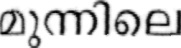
മുന്നിലെ
